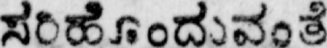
ಸರಿಹೊಂದುವಂತೆ
